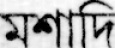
মশাদি
